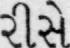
રીસે
